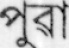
পুৱা
